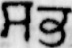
ਸਭ
